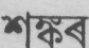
শঙ্কৰ
